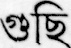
গুছি
